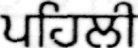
ਪਹਿਲੀ
